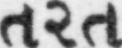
તરત
